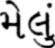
મેલું
